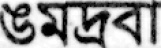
ঙমদ্রবা
